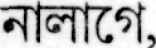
নালাগে,
